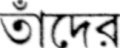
তাঁদের
